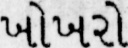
ખોખરો
